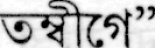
তম্বীগে”
